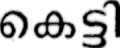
കെട്ടി
